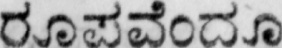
ರೂಪವೆಂದೂ
